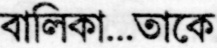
বালিকা...তাকে
